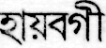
হায়বগী
